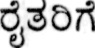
ರೈತರಿಗೆ
